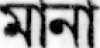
মানা
